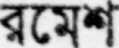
রমেশ
